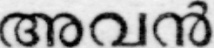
അവന്‍
